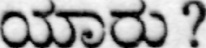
ಯಾರು?
